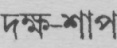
দক্ষ-শাপ
